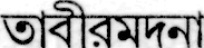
তাবীরমদনা
